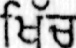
ਖਿੱਚ
